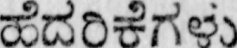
ಹೆದರಿಕೆಗಳು
